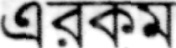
এরকম
